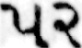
પર
